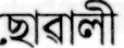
ছোৱালী
